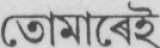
তোমাৰেই
